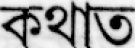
কথাত
